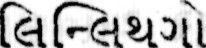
લિન્લિથગો
